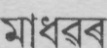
মাধৱৰ
